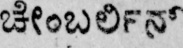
ಚೇಂಬರ್ಲಿನ್
